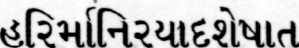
હરિર્માનિરયાદશેષાત
